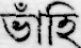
ভাঁহি
